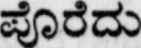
ಪೊರೆದು
